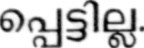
പ്പെട്ടില്ല.
